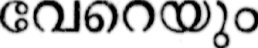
വേറെയും
